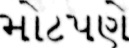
મોટપણે
